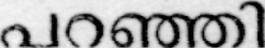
പറഞ്ഞി
